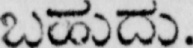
ಬಹುದು.
